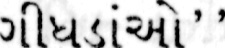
ગીધડાંઓ"
